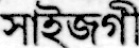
সাইজগী
